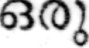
ഒരു
